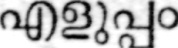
എളുപ്പം
